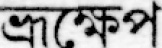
ভ্রূক্ষেপ
